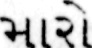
મારો
